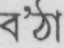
ব'ঠা
